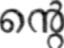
ന്റെ
